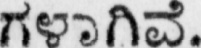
ಗಳಾಗಿವೆ.
